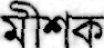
মীশক
